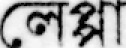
লেপ্পা
